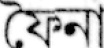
ফৈনা
